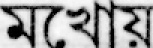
মখোয়
